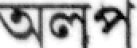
অলপ
